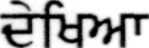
ਦੇਖਿਆ
